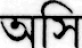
অসি
